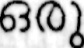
ഒരു
